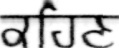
ਕਹਿਣ
